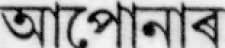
আপোনাৰ
